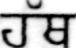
ਹੱਥ
